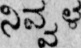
ನಿವ್ವಳ
